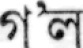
গ'ল
